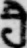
ਹੈ
